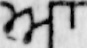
ਆ
